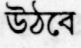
উঠবে
